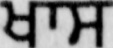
ਖਾਸ
